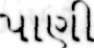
પાણી
